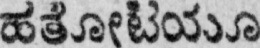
ಹತೋಟಿಯೂ
